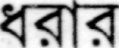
ধরার
